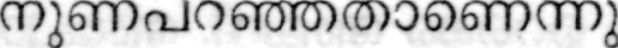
നുണപറഞ്ഞതാണെന്നു
